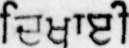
ਦਿਖਾਈ
